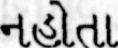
નહોતા
